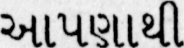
આપણાથી
